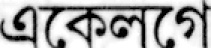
একেলগে
